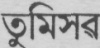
তুমিসৱ
